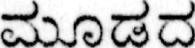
ಮೂಡದ
